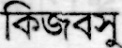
কিজবসু
